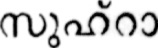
സുഹ്റാ
